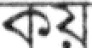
কয়
